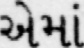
એમાં
